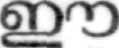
ഈ
